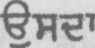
ਉਸਦਾ
